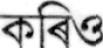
কৰিও
